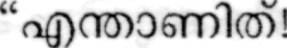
“എന്താണിത്!
